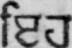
ਇਹ
